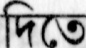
দিতে
